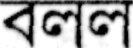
বলল
